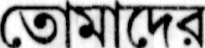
তোমাদের
